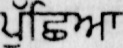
ਪੁੱਛਿਆ
